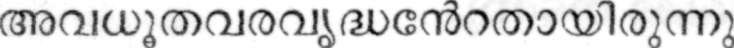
അവധൂതവരവൃദ്ധന്റേതായിരുന്നു
